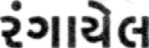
રંગાયેલ
